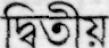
দ্বিতীয়
